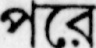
পরে
